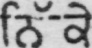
ਨਿੱਕੇ
